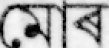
মোৰ
